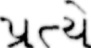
પ્રત્યે
